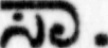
ಸಾ.
